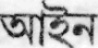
আইন
